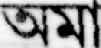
অমা
